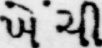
ખેંચી
